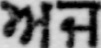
ਅਜ
